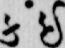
કંઈ
